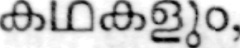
കഥകളും,
